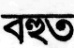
বহুত
